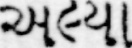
અલ્યા
